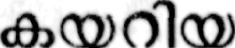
കയറിയ
